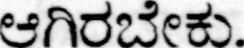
ಆಗಿರಬೇಕು.
